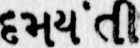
દમયંતી
